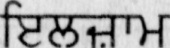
ਇਲਜ਼ਾਮ
